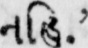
નહિ.'
